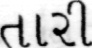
તારી
